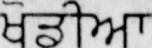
ਖੋਡੀਆ
